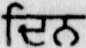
ਦਿਨ
